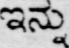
ಇನ್ನು
